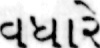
વધારે
